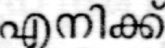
എനിക്ക്
